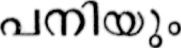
പനിയും
